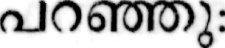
പറഞ്ഞു:
